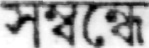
সম্বন্ধে
